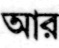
আর
